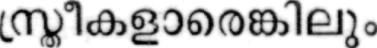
സ്ത്രീകളാരെങ്കിലും
